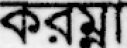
করম্না
